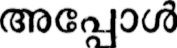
അപ്പോള്‍
